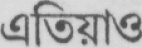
এতিয়াও
